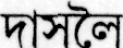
দাসলৈ
